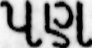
પણ
